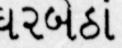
ઘરબેઠાં
